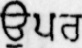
ਉਪਰ
